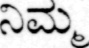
ನಿಮ್ಮ
